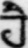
ਹੈ
